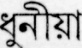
ধুনীয়া
